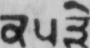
ਕਪੜੇ
